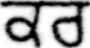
ਕਰ
